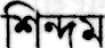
শিন্দম
